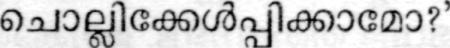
ചൊല്ലിക്കേള്‍പ്പിക്കാമോ?’
